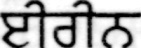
ਈਰੀਨ
